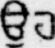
ਉਹ
